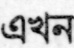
এখন
